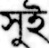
সুই
